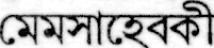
মেমসাহেবকী
